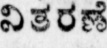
ವಿತರಣೆ
